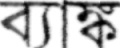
ব্যাঙ্ক
